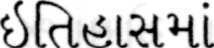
ઇતિહાસમાં
